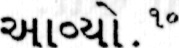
આવ્યો.૧૦
